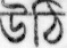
উঠি
